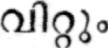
വിറ്റും
